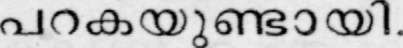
പറകയുണ്ടായി.
